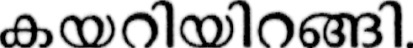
കയറിയിറങ്ങി.
